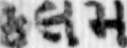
કલમ
